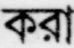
করা
